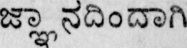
ಜ್ಞಾನದಿಂದಾಗಿ
